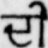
ਦੀ
